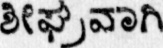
ಶೀಘ್ರವಾಗಿ
